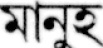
মানুহ
